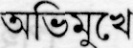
অভিমুখে
